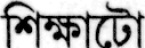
শিক্ষাটো
